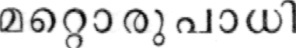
മറ്റൊരുപാധി
